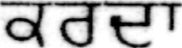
ਕਰਦਾ
